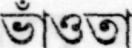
ভাঁওতা
